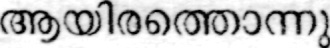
ആയിരത്തൊന്നു
